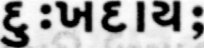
દુઃખદાય
